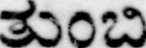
ತುಂಬಿ
